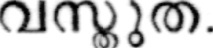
വസ്തുത.
